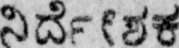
ನಿರ್ದೇಶಕ
